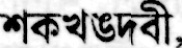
শকখঙদবী,
